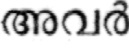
അവര്‍
